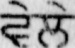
ਵੇਲੇ
